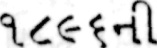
૧૮૯૬ની
